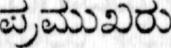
ಪ್ರಮುಖರು
